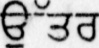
ਉੱਤਰ
